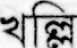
খল্লি
